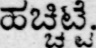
ಹಚ್ಚಿಟ್ಟೆ.
